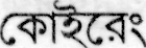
কোইরেং
